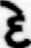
દે
